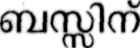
ബസ്സിന്
